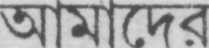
আমাদের
